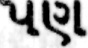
પણ
